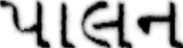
પાલન
